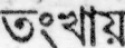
তংখায়
